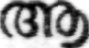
ആ
